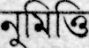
নুমিত্তি
